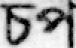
চপ
